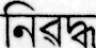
নিৱদ্ধ
